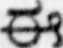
ಈ
